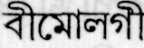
বীমোলগী
